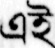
এই
